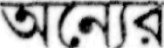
অন্যের
